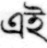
এই
